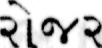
રોજર
